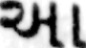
આ
